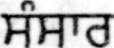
ਸੰਸਾਰ
